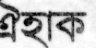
ঐহাক
